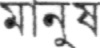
মানুষ
